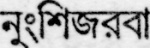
নুংশিজরবা
